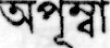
অপূম্বা
